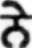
ਨੇ
